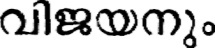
വിജയനും
